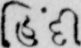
હિંદી
